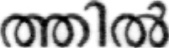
ത്തില്‍
